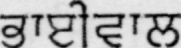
ਭਾਈਵਾਲ
